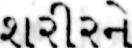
શરીરને
